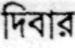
দিবার
